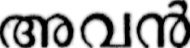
അവന്‍
